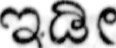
ಇಡೀ
